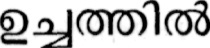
ഉച്ചത്തില്‍
